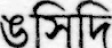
ঙসিদি
